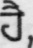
ਹੈ,
